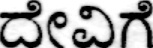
ದೇವಿಗೆ
